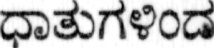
ಧಾತುಗಳಿಂದ
